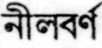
নীলবর্ণ
